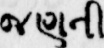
જણની
